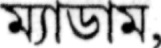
ম্যাডাম,
